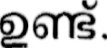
ഉണ്ട്.
